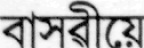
বাসৱীয়ে
